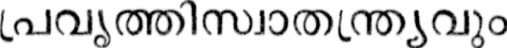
പ്രവൃത്തിസ്വാതന്ത്ര്യവും
